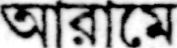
আরামে
